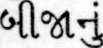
બીજાનું
